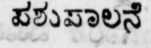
ಪಶುಪಾಲನೆ
